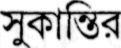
সুকান্তির
